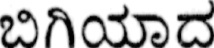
ಬಿಗಿಯಾದ
